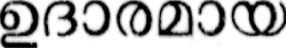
ഉദാരമായ
